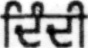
ਦਿੰਦੀ
